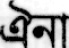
ঐনা
